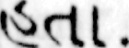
હતા.
